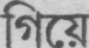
গিয়ে
